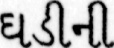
ઘડીની
